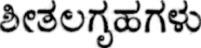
ಶೀತಲಗೃಹಗಳು
